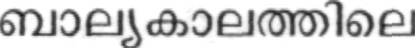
ബാല്യകാലത്തിലെ
